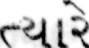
ત્યારે
